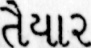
તૈયાર
